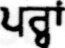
ਪਰ੍ਹਾਂ
